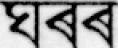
ঘৰৰ
